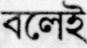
বলেই
